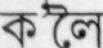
ক'লৈ
